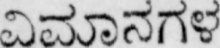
ವಿಮಾನಗಳ
